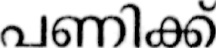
പണിക്ക്
